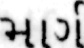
માર્ગ
